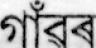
গাঁৱৰ
